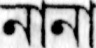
নানা
